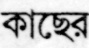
কাছের
